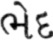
ભેદ
